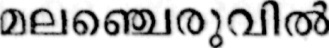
മലഞ്ചെരുവില്‍
